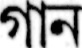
গান
